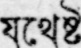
যথেষ্ট
